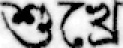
শুখ্রে
